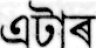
এটাৰ
